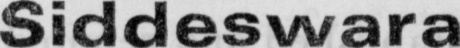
Siddeswara
